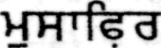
ਮੁਸਾਫ਼ਿਰ
